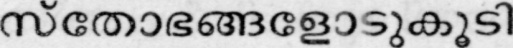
സ്തോഭങ്ങളോടുകൂടി
